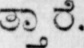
ತ್ತಾರೆ.
